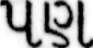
પણ
